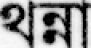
থন্না
